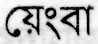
য়েংবা
